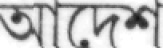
আদেশ
